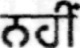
ਨਹੀਂ
